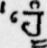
''ਹੂੰ
